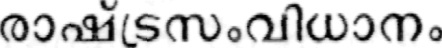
രാഷ്ട്രസംവിധാനം
